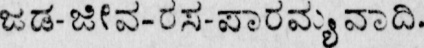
ಜಡ-ಜೀವ-ರಸ-ಪಾರಮ್ಯವಾದಿ.
